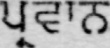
ਪ੍ਰਵਾਨ
